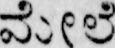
ಮೇಲೆ
